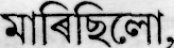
মাৰিছিলো,
